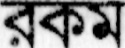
রকম
